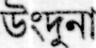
উংদুনা
